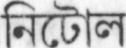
নিটোল
